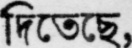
দিতেছে,
